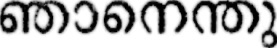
ഞാനെന്തു
